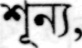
শূন্য,
